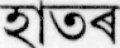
হাতৰ
